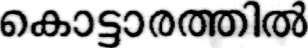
കൊട്ടാരത്തില്‍
